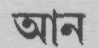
আন
